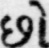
છો
